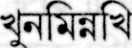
খুনমিন্নখি
